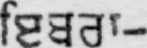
ਇਬਰਾ-
